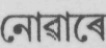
নোৱাৰে
